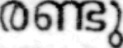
രണ്ടു
